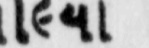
ચાલ્યા
